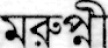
মরুপ্নী
